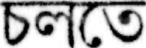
চলতে
